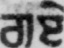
ਗਏ
